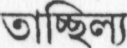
তাচ্ছিল্য
